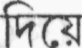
দিয়ে
